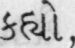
કહ્યો,
